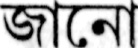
জানো
